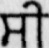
ਸੀ
